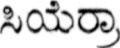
ಸಿಯೆರ್ರಾ
